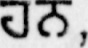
ਹਨ,
